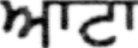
ਆਟਾ
